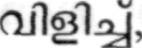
വിളിച്ച്,
